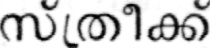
സ്ത്രീക്ക്
